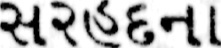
સરહદના
